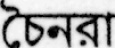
চৈনরা
